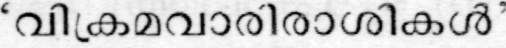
‘വിക്രമവാരിരാശികള്‍’
